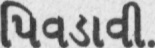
પિવડાવી.
